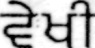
ਵੇਖੀ
